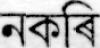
নকৰি
